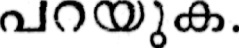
പറയുക.
